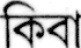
কিবা
